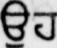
ਉਹ
